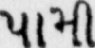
પામી
